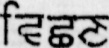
ਵਿਛਣ
